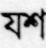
যশ
